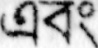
এবং
